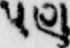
પણ
